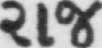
રાજ
